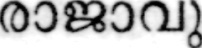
രാജാവു
